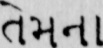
તેમના
